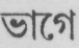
ভাগে
